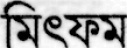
মিৎফম
